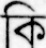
কি
